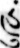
હું
